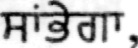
ਸਾਂਭੇਗਾ,
